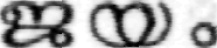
ജയം
